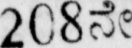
208ನೇ
